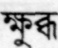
ক্ষুব্ধ
